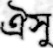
ঐসু
